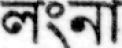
লংনা
